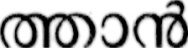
ത്താന്‍
